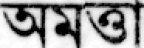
অমত্তা
